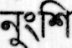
নুংশি
